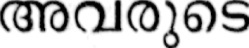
അവരുടെ
